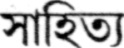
সাহিত্য
